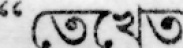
"তেখেত
